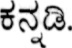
ಕನ್ನಡಿ.
